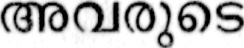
അവരുടെ
